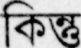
কিন্তু
